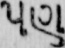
પણ
